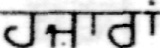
ਹਜ਼ਾਰਾਂ
